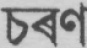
চৰণ
